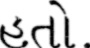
હતો.
